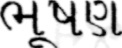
ભૂષણ
